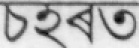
চহৰত
